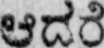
ಆದರೆ
